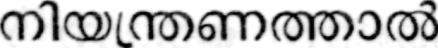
നിയന്ത്രണത്താല്‍
